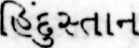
હિંદુસ્તાન
